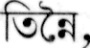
তিন্নৈ,
